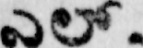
ಎಲ್.
